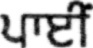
ਪਾਈਂ
